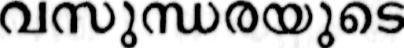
വസുന്ധരയുടെ
